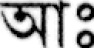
আঃ
